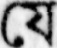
যে
